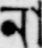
না
